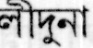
লীদুনা
